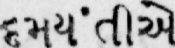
દમયંતીએ
